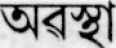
অৱস্থা
